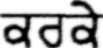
ਕਰਕੇ
